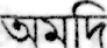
অমদি
